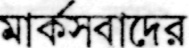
মার্কসবাদের
